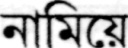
নামিয়ে
